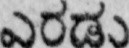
ಎರಡು
